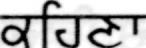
ਕਹਿਣਾ
